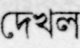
দেখল
